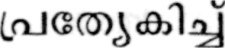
പ്രത്യേകിച്ച്
